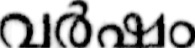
വര്‍ഷം
